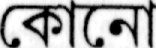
কোনো
